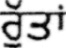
ਰੁੱਤਾਂ
